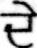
ਦੇ
